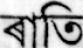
ৰাতি
